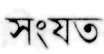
সংযত
